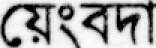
য়েংবদা
